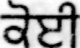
ਕੋਈ
